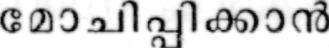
മോചിപ്പിക്കാന്‍
